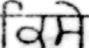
ਕਿਸੇ
